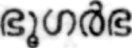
ഭൂഗര്‍ഭ
